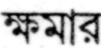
ক্ষমার
